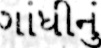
ગાંધીનું
